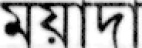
ময়াদা
